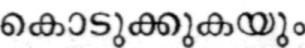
കൊടുക്കുകയും
